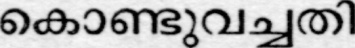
കൊണ്ടുവച്ചതി
